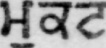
ਮੁਕਟ
